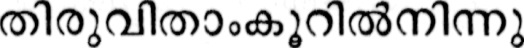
തിരുവിതാംകൂറില്‍നിന്നു
